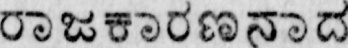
ರಾಜಕಾರಣನಾದ
